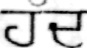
ਹੱਦ
